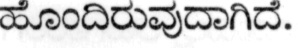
ಹೊಂದಿರುವುದಾಗಿದೆ.
